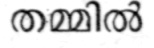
തമ്മില്‍
